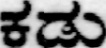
ಕಡು
